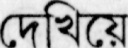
দেখিয়ে
